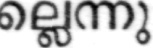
ല്ലെന്നു
